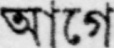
আগে
